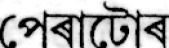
পেৰাটোৰ
